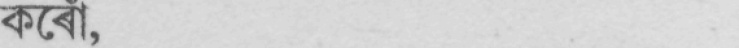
কৰোঁ,
